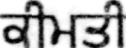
ਕੀਮਤੀ
